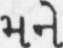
મને
